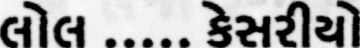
લોલ.......કેસરીયો
